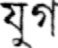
যুগ
